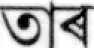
তাৰ
